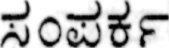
ಸಂಪರ್ಕ
